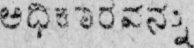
ಅಧಿಕಾರವನ್ನು
